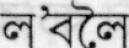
ল'বলৈ
